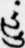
હું
